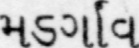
મડર્ગાંવ
